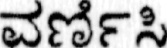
ವರ್ಣಿಸಿ
